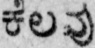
ಕೆಲವು
